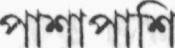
পাশাপাশি
